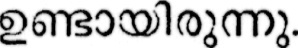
ഉണ്ടായിരുന്നു.
